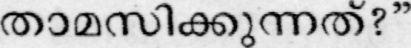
താമസിക്കുന്നത്?”
